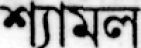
শ্যামল
